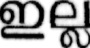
ഇല്ല
